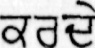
ਕਰਦੇ
